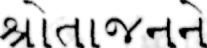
શ્રોતાજનને
